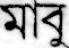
মাবু
